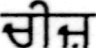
ਚੀਜ਼
